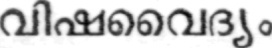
വിഷവൈദ്യം
